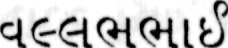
વલ્લભભાઈ
